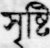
সৃষ্টি
